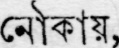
নৌকায়,
